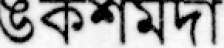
ঙকশমদা
